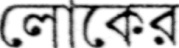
লোকের
